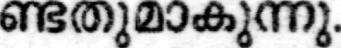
ണ്ടതുമാകുന്നു.
